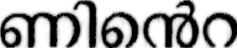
ണിന്റെ
